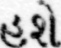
હશે
